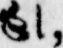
હા,
